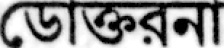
ডোক্তরনা
